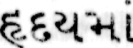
હૃદયમાં
